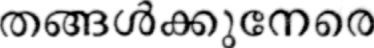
തങ്ങള്‍ക്കുനേരെ
